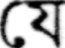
যে
